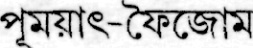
পূময়াৎ-ফৈজোম
